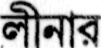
লীনার
